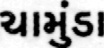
ચામુંડા
